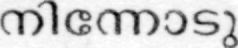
നിന്നോടു
